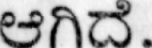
ಆಗಿದೆ.
